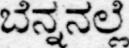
ಬೆನ್ನನಲ್ಲೆ
